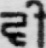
ਵੀ
